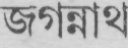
জগন্নাথ
